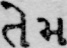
તેમ
